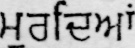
ਮੁਰਦਿਆਂ
